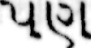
પણ
